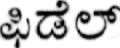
ಫಿಡೆಲ್
